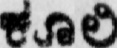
ಕೂಲಿ
